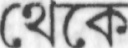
থেকে
